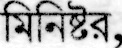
মিনিষ্টর,
